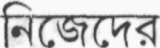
নিজেদের
